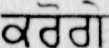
ਕਰੋਗੇ
